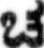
ಚ
